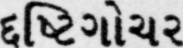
દ્દષ્ટિગોચર
